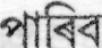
পাৰিব
